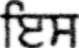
ਇਸ
